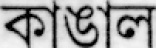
কাঙাল
